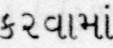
કરવામાં
